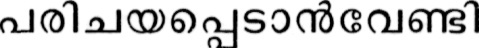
പരിചയപ്പെടാന്‍വേണ്ടി
